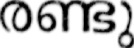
രണ്ടു
